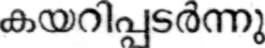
കയറിപ്പടര്‍ന്നു
